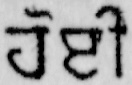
ਹੋਈ
